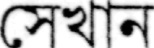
সেখান
